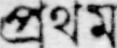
প্রথম
